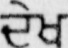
ਦੇਖ
